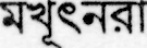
মখূৎনরা
